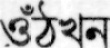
ওঁঠখন
